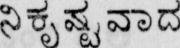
ನಿಕೃಷ್ಟವಾದ
